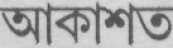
আকাশত
